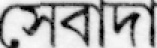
সেবাদা
